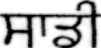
ਸਾਡੀ
